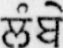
ਲੰਬੇ
